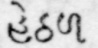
હેઠળ
